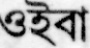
ওইবা
